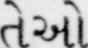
તેઓ
